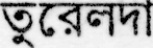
তুরেলদা
